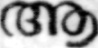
ആ
